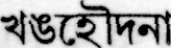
খঙহৌদনা
